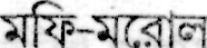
মফি-মরোল
